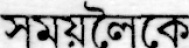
সময়লৈকে
